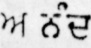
ਅਨੰਦ
